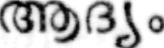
ആദ്യം
